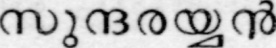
സുന്ദരയ്യന്‍
